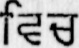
ਵਿਚ
